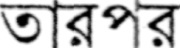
তারপর
